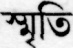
স্মৃতি
